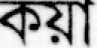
কয়া
